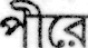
পীরে
